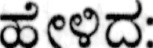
ಹೇಳಿದ:
